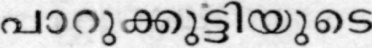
പാറുക്കുട്ടിയുടെ
